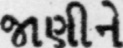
જાણીને
